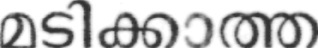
മടിക്കാത്ത
